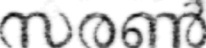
സരണ്‍
